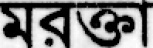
মরক্তা
